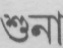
শুনা
